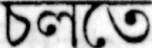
চলতে
